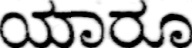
ಯಾರೂ
